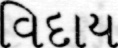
વિદાય
